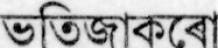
ভতিজাকৰো
